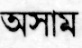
অসাম
